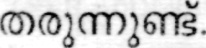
തരുന്നൂണ്ട്.
